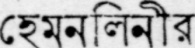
হেমনলিনীর
